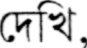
দেখি,
